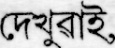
দেখুৱাই,
